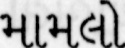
મામલો
